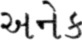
અનેક
